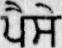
ਪੈਸੇ
